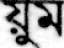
য়ুম
